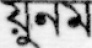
য়ুনম
